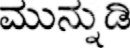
ಮುನ್ನುಡಿ
